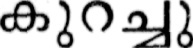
കുറച്ചു
